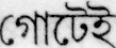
গোটেই
